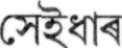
সেইধাৰ
